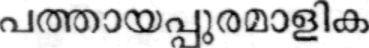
പത്തായപ്പുരമാളിക
